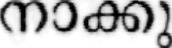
നാക്കു
